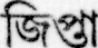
জিপ্তা
